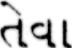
તેવા
